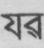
যৱ
